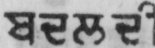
ਬਦਲਦੀ
